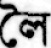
লৈ
